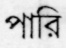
পারি
